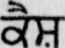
ਕੈਸ਼
